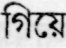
গিয়ে
